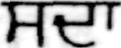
ਸਦਾ
